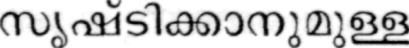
സൃഷ്ടിക്കാനുമുള്ള
